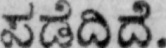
ಪಡೆದಿದೆ.
